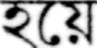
হয়ে
